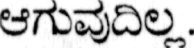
ಆಗುವುದಿಲ್ಲ.
